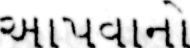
આપવાનો
